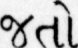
જતો
